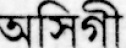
অসিগী
